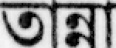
তান্না
